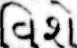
વિશે
